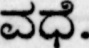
ವಧೆ.
